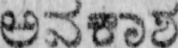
ಅವಕಾಶ
